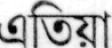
এতিয়া
